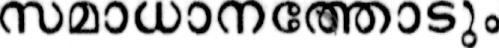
സമാധാനത്തോടും
